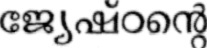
ജ്യേഷ്ഠന്റെ
